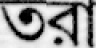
তরা
